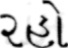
રહો
